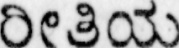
ರೀತಿಯ
